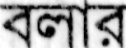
বলার
